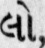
લો,
